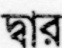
দ্বার
